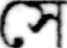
সে
